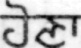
ਹੋਣਾ
